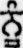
ਨੂੰ
